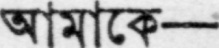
আমাকে—
